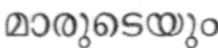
മാരുടെയും
